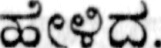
ಹೇಳಿದ.
